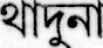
থাদুনা
